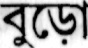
বুড়ো
